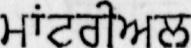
ਮਾਂਟਰੀਅਲ
